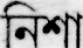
নিশা
